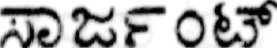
ಸಾರ್ಜಂಟ್
